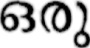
ഒരു
